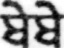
ਬੇਬੇ
